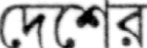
দেশের
